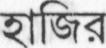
হাজির
